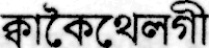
ক্বাকৈথেলগী
